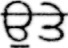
ਉਤੇ
